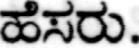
ಹೆಸರು.
